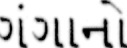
ગંગાનો
